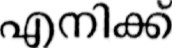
എനിക്ക്
